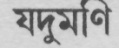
যদুমণি
